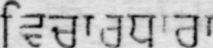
ਵਿਚਾਰਧਾਰਾ
